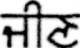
ਜੀਣ
